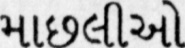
માછલીઓ
